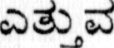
ಎತ್ತುವ
